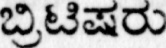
ಬ್ರಿಟಿಷರು
